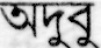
অদুবু
